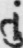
તું
